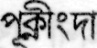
পূক্নীংদা
